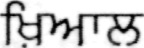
ਖ਼ਿਆਲ
